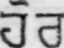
ਹੋਰ
